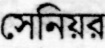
সেনিয়র
